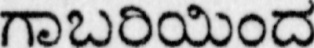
ಗಾಬರಿಯಿಂದ
